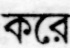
করে
